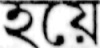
হয়ে
